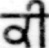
ਕੀ
